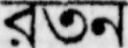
রতন
